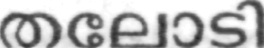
തലോടി
